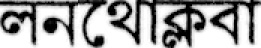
লনথোক্লবা
